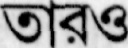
তারও
